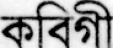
কবিগী
